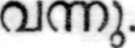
വന്നു.
